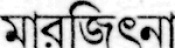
মারজিৎনা
